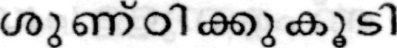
ശുണ്ഠിക്കുകൂടി
